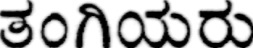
ತಂಗಿಯರು
